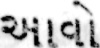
આવો
